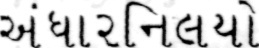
અંધારનિલયો
